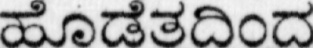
ಹೊಡೆತದಿಂದ
